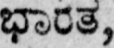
ಭಾರತ,
